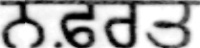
ਨਫ਼ਰਤ
